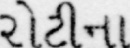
રોટીના
